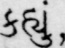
કહ્યું,
